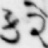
કરે
